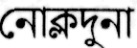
নোক্লদুনা
